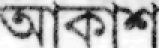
আকাশ
